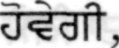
ਹੋਵੇਗੀ,
